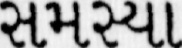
સમસ્યા
